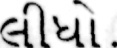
લીધો.
